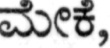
ಮೇಕೆ,
